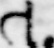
ત.
